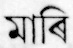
মাৰি
